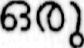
ഒരു
